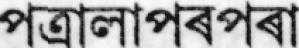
পত্ৰালাপৰপৰা
